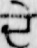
ਦੇ
